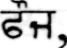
ਫੌਜ,
